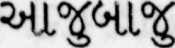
આજુબાજુ
